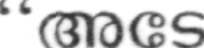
"അടേ
